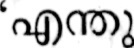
‘എന്തു
